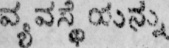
ವ್ಯವಸ್ಥೆಯನ್ನು
